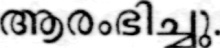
ആരംഭിച്ചു.
